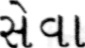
સેવા
